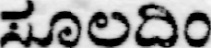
ಸೂಲದಿಂ
